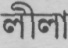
লীলা
